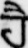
ਹੈ
